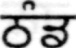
ਠੰਡ
